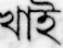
খাই
